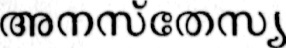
അനസ്തേസ്യ
